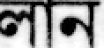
লান
